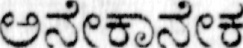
ಅನೇಕಾನೇಕ
